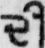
ਦੀ
